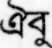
ঐবু
